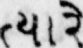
ત્યારે
